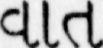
વાત
